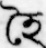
হৈ
